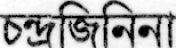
চন্দ্রজিনিনা
